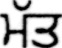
ਮੱਤ
